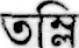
তম্লি
